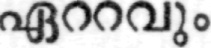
ഏററവും
